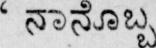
‘ನಾನೊಬ್ಬ
